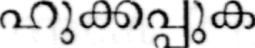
ഹുക്കപ്പുക
